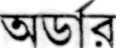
অর্ডার
